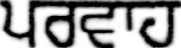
ਪਰਵਾਹ
